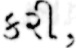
કરી,
